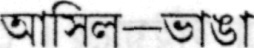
আসিল—ভাঙা
